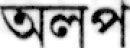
অলপ
